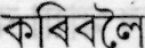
কৰিবলৈ
